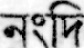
নংদি
